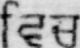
ਵਿਚ
